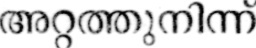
അറ്റത്തുനിന്ന്
